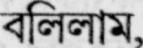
বলিলাম,
